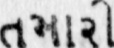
તમારી
